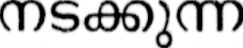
നടക്കുന്ന
